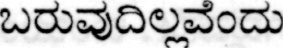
ಬರುವುದಿಲ್ಲವೆಂದು
